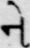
ને
